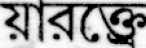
য়ারক্ত্রে
